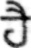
ਹੈ
